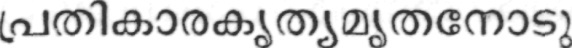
പ്രതികാരകൃത്യമൃതനോടു
